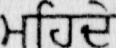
ਮਹਿਦੇ
